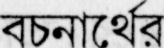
বচনার্থের
